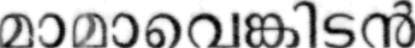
മാമാവെങ്കിടന്‍
